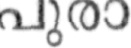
പുരാ
